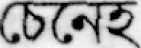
চেনেহ
